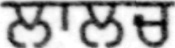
ਲਾਲਚ
